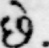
છે.
